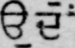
ਉਦੋਂ
